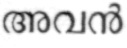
അവന്‍
